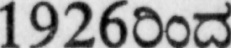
1926ರಿಂದ
